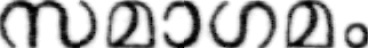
സമാഗമം
